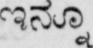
ಇನ್ನೂ
